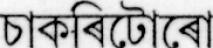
চাকৰিটোৰো
